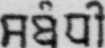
ਸਬੰਧੀ
